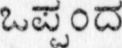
ಒಪ್ಪಂದ
